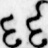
દર્દ
